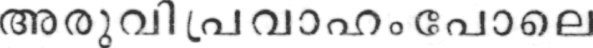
അരുവിപ്രവാഹംപോലെ
